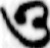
ও
